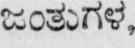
ಜಂತುಗಳ,
